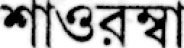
শাওরম্বা
